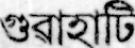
গুৱাহাটি
